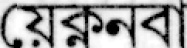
য়েক্ননবা
